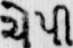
ચેપી
